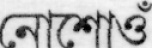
নোশোওঁ
